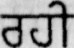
ਰਹੀ
